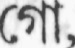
গো,
